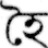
হৈ
